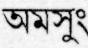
অমসুং
